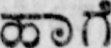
ಹಾಗೆ
